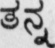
ತನ್ನ
